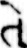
તે
